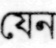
যেন
